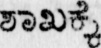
ಶಾಖಕ್ಕೆ
